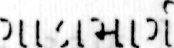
ગાડામાર્ગ
